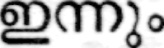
ഇന്നും
